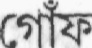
গোঁফ
